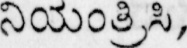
ನಿಯಂತ್ರಿಸಿ,
